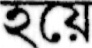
হয়ে
